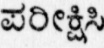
ಪರೀಕ್ಷಿಸಿ
